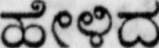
ಹೇಳಿದ
